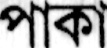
পাকা
